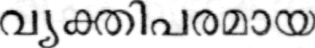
വ്യക്തിപരമായ
